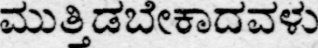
ಮುತ್ತಿಡಬೇಕಾದವಳು
